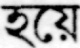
হয়ে
